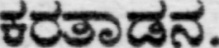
ಕರತಾಡನ.
